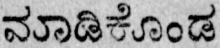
ಮಾಡಿಕೊಂಡ
